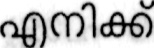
എനിക്ക്
